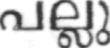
പല്ലു
